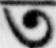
ত
